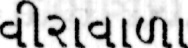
વીરાવાળા
